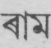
ৰাম
